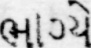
ભાગ્યે
